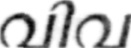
വിവ
